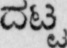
ದಟ್ಟ
